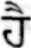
ਹੈ
